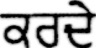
ਕਰਦੇ
